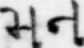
મન
